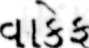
વાકેફ
